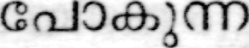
പോകുന്ന
